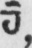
ਹੋ,
